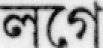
লগে
